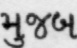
મુજબ
